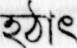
হঠাত্
